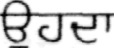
ਉਹਦਾ
